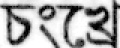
চংখ্রে
